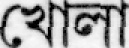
খোলা
